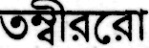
তম্বীররো
